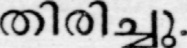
തിരിച്ചു.
